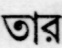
তার
